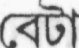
বেটা
